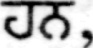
ਹਨ,
